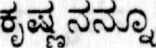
ಕೃಷ್ಣನನ್ನೂ
